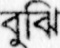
বুঝি
